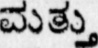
ಮತ್ತು
